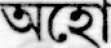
অহো
